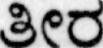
ತೀರ
